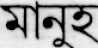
মানুহ
